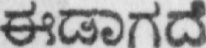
ಈಡಾಗದೆ
